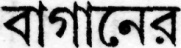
বাগানের
